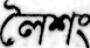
লৈশং
